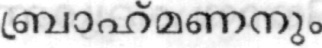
ബ്രാഹ്മണനും
